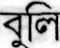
বুলি
